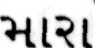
મારા
